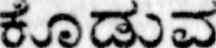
ಕೊಡುವ
